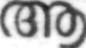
ആ
